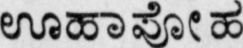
ಊಹಾಪೋಹ
